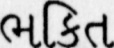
ભક્તિ
